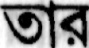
তার
